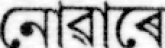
নোৱাৰে
